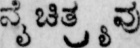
ವೈಚಿತ್ರ್ಯವು
